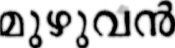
മുഴുവന്‍
